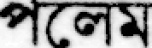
পলেম
